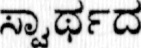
ಸ್ವಾರ್ಥದ
